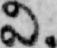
ವಿ.
